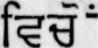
ਵਿਚੋਂ
